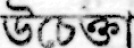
উচেক্তা
